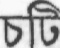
চটি
